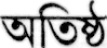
অতিষ্ঠ
